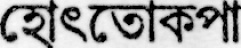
হোৎতোকপা
